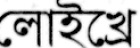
লোইখ্রে
